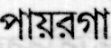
পায়রগা
